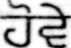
ਹੋਵੇ
